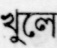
খুলে
